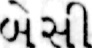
ખેસી
